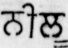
ਨੀਲੂ
